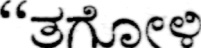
"ತಗೋಳಿ
